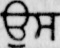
ਉਸ
